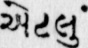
એટલું
